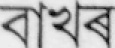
বাখৰ
